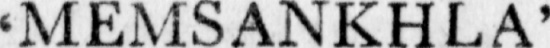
‘MEMSANKHLA’
